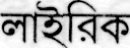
লাইরিক
